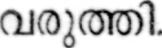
വരുത്തി.
